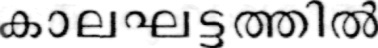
കാലഘട്ടത്തില്‍
